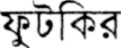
ফুটকির
